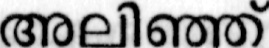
അലിഞ്ഞ്
